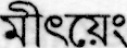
মীৎয়েং
